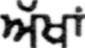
ਅੱਖਾਂ
